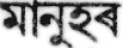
মানুহৰ
